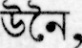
উনৈ,
